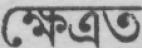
ক্ষেত্ৰত
